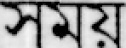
সময়
